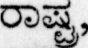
ರಾಷ್ಟ್ರ,
